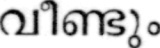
വീണ്ടും
